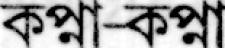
কপ্না-কপ্না
